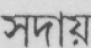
সদায়
